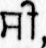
ਸੀ,
